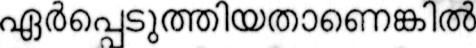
ഏര്‍പ്പെടുത്തിയതാണെങ്കില്‍
